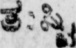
ತುಷ್ಟಿ
